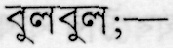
বুলবুল;-
